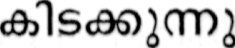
കിടക്കുന്നു
